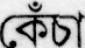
কেঁচা
